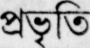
প্রভৃতি
